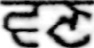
ਵਣ
